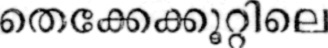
തെക്കേക്കൂറ്റിലെ
